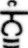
ਨੂੰ
